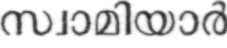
സ്വാമിയാര്‍
